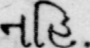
નહિ.
